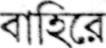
বাহিরে
